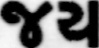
જય
